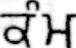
ਕੰਮ
